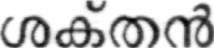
ശക്തന്‍
